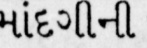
માંદગીની
